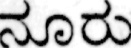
ನೂರು
